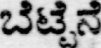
ಬೆಟ್ಟೆನೆ
